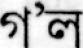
গ'ল
